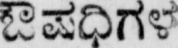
ಔಷಧಿಗಳ
